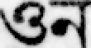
ওন
